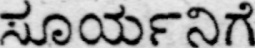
ಸೂರ್ಯನಿಗೆ
